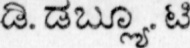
ಡಿ.ಡಬ್ಲ್ಯೂ.ಟಿ
